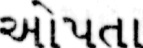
ઓપતા
